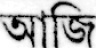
আজি
